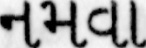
નમવા
